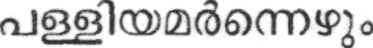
പള്ളിയമര്‍ന്നെഴും
